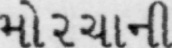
મોરચાની
